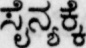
ಸೈನ್ಯಕ್ಕೆ
